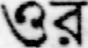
ওর
